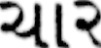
ચાર
